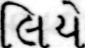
લિયે
